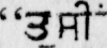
''ਤੁਸੀਂ
